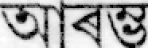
আৰম্ভ
